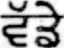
ਵੱਡੇ
